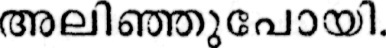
അലിഞ്ഞുപോയി.
